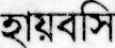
হায়বসি
